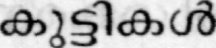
കുട്ടികള്‍
